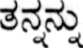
ತನ್ನನ್ನು
